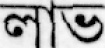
লাভ
